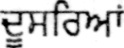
ਦੂਸਰਿਆਂ
